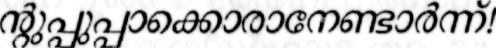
ന്റുപ്പുപ്പാക്കൊരാനേണ്ടാര്‍ന്ന്!
